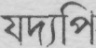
যদ্যপি
